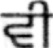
ਵੀ
